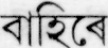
বাহিৰে
